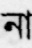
না
